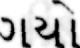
ગયો
